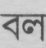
বল
